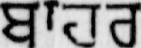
ਬਾਹਰ
